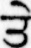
ਤੇ
